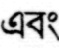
এবং
